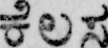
ಕೆಲಸ
